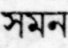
সমন
